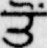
ਤੋਂ
